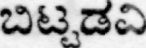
ಬಿಟ್ಟಡವಿ
